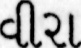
વીરા
